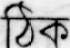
ঠিক
